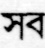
সব
